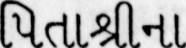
પિતાશ્રીના
